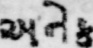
અનેક
